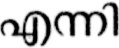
എന്നി
